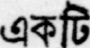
একটি
